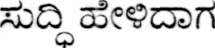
ಸುದ್ಧಿಹೇಳಿದಾಗ
